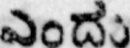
ಎಂದು
